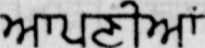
ਆਪਣੀਆਂ
